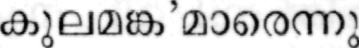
കുലമങ്ക'മാരെന്നു
